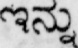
ಇನ್ನು
